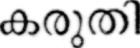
കരുതി
